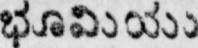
ಭೂಮಿಯು
